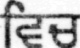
ਵਿਚ
